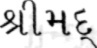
શ્રીમદ્
